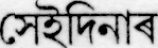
সেইদিনাৰ
